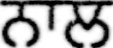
ਨਾਲ
